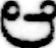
ಆ
